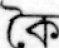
কৈ
